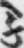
કે
